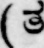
(ತ
